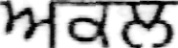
ਅਕਲ
